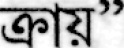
ক্রায়”
